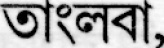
তাংলবা,
